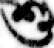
শু
